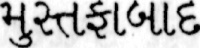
મુસ્તફાબાદ
